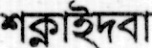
শক্নাইদবা
